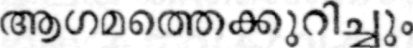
ആഗമത്തെക്കുറിച്ചും
